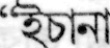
“ইচানা
